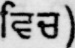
ਵਿਚ)
